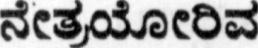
ನೇತ್ರಯೋರಿವ
